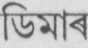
ডিমাৰ
